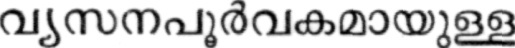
വ്യസനപൂര്‍വകമായുള്ള
